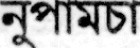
নুপামচা
